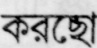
করছো
